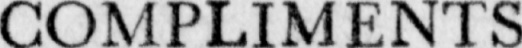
COMPLIMENTS
